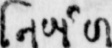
નિર્બળ
